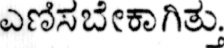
ಎಣಿಸಬೇಕಾಗಿತ್ತು.
